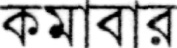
কমাবার
